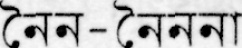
নৈন-নৈননা
